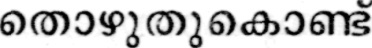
തൊഴുതുകൊണ്ട്
